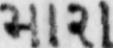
મારા
